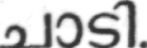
ചാടി.
